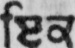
ਇਕ
